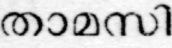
താമസി
